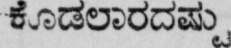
ಕೊಡಲಾರದಷ್ಟು
